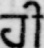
ਹੀ
